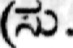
(ಸು.
